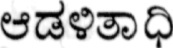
ಆಡಳಿತಾಧಿ
